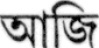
আজি
